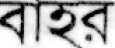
বাহর
